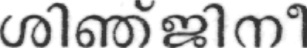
ശിഞ്ജിനീ
